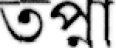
তপ্না
